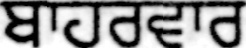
ਬਾਹਰਵਾਰ
